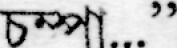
চম্পা..."
